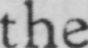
the
